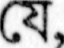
যে,
